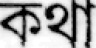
কথা
